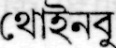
থোইনবু
